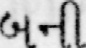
બની
